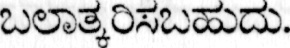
ಬಲಾತ್ಕರಿಸಬಹುದು.
